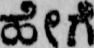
ಹೇಗೆ
